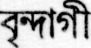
বৃন্দাগী
